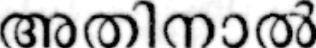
അതിനാല്‍
